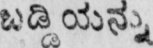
ಬಡ್ಡಿಯನ್ನು
